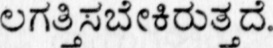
ಲಗತ್ತಿಸಬೇಕಿರುತ್ತದೆ.
